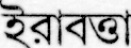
ইরাবত্তা
